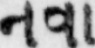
નવા
